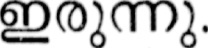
ഇരുന്നു.
